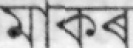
মাকৰ
